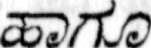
ಹಾಗೂ
